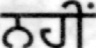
ਨਹੀਂ
